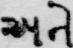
અને
